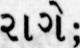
રાગે;
